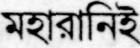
মহারানিই
